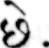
છે.
